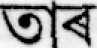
তাৰ
